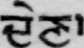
ਦੇਣਾ
